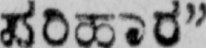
ಪರಿಹಾರ”
